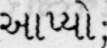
આપ્યો;
